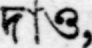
দাও,
